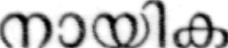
നായിക
